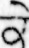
ਕੇ
